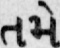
તમે
